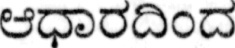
ಆಧಾರದಿಂದ
